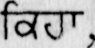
ਕਿਹਾ,
